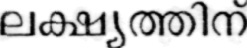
ലക്ഷ്യത്തിന്
